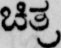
ಚಿತ್ರ
